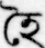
হৈ
